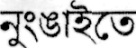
নুংঙাইতে
